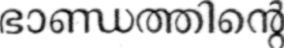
ഭാണ്ഡത്തിന്റെ
